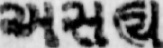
અસહ્ય
